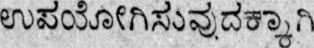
ಉಪಯೋಗಿಸುವುದಕ್ಕಾಗಿ
